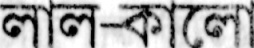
লাল-কালো
